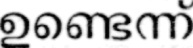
ഉണ്ടെന്ന്
